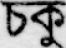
চকু
